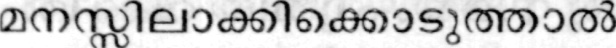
മനസ്സിലാക്കിക്കൊടുത്താല്‍
